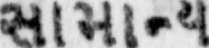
સામાન્ય
